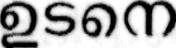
ഉടനെ
